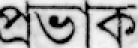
প্রভাক
